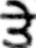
ਤੇ
